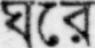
ঘরে
